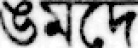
ঙমদে
